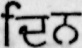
ਦਿਨ
